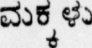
ಮಕ್ಕಳು
